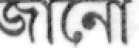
জানো
